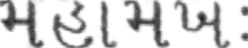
મહામખઃ
